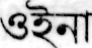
ওইনা
